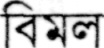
বিমল
